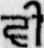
ਵੀ
